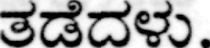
ತಡೆದಳು.
